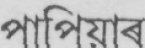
পাপিয়াৰ
